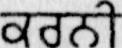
ਕਰਨੀ
